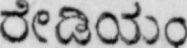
ರೇಡಿಯಂ
